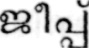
ജീപ്പ്
